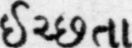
ઈચ્છતા
